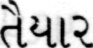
તૈયાર
